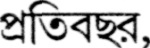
প্রতিবছর,
